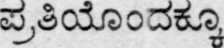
ಪ್ರತಿಯೊ೦ದಕ್ಕೊ
